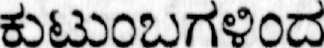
ಕುಟುಂಬಗಳಿಂದ
